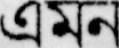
এমন
